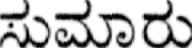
ಸುಮಾರು
